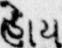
હોય
